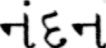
નંદન
